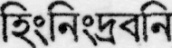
হিংনিংদ্রবনি
